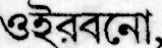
ওইরবনো,
